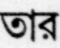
তার
